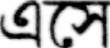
এসে
